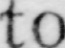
to
